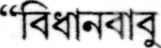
“বিধানবাবু
